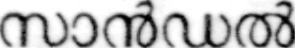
സാന്‍ഡല്‍
